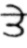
ਤੇ
